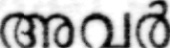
അവര്‍
